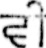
ਵੀ
